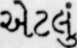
એટલું
